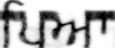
ਪਿਆ
